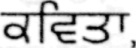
ਕਵਿਤਾ,
